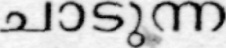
ചാടുന്ന
